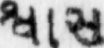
શ્વાસ
